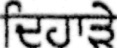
ਦਿਹਾੜੇ
